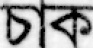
চাক
